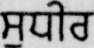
ਸੁਧੀਰ
